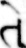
તે
